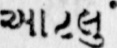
આટલું
